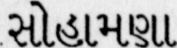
સોહામણા
